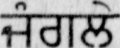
ਜੰਗਲੇ
